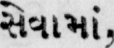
સેવામાં,
